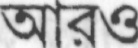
আরও
